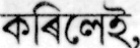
কৰিলেই,
